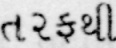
તરફથી
